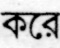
করে
